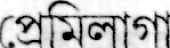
প্রেমিলাগা
